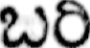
ಬರಿ
